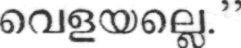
വെളയല്ലെ."
